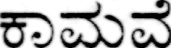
ಕಾಮವೆ
